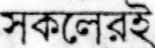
সকলেরই
